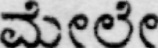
ಮೇಲೇ
